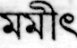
মমীৎ
